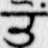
ਤੋਂ
